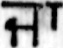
ਜਾ
